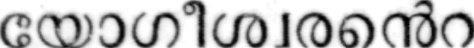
യോഗീശ്വരന്റെ
